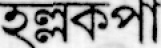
হল্লকপা
